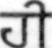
ਹੀ
